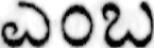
ಎಂಬ
